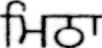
ਮਿਠਾ
